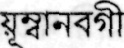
য়ূম্বানবগী
